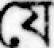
যে
